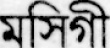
মসিগী
